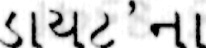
ડાયટ'ના
